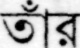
তাঁর
